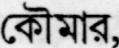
কৌমার,
